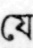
যে
